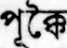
পূক্কৈ
